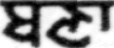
ਬਣਾ
